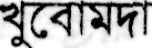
খুবোমদা
